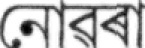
নোৱৰা
